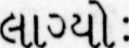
લાગ્યો:
